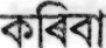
কৰিবা
